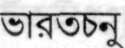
ভারতচনু
